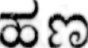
ಹಣ
